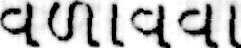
વળાવવા
